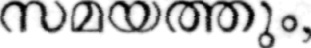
സമയത്തും,
